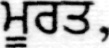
ਮੂਰਤ,
